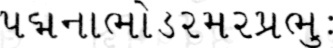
પદ્મનાભોડરમરપ્રભુઃ
